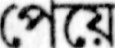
পেয়ে
